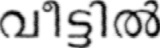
വീട്ടില്‍
